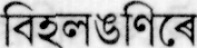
বিহলঙণিৰে
